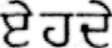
ਏਹਦੇ
